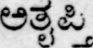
ಅತೃಪ್ತಿ
